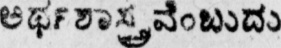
ಅರ್ಥಶಾಸ್ತ್ರವೆಂಬುದು
